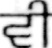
ਵੀ
